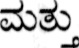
ಮತ್ತು
